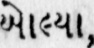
બોલ્યા,
